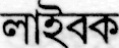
লাইবক
